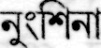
নুংশিনা
